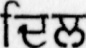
ਦਿਲ
